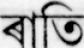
ৰাতি
